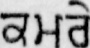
ਕਮਰੇ
